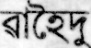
ৱাহৈদু
